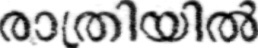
രാത്രിയില്‍
